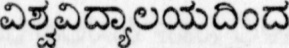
ವಿಶ್ವವಿದ್ಯಾಲಯದಿಂದ
